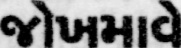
જોખમાવે
